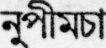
নুপীমচা
